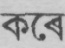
কৰে
